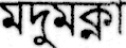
মদুমক্না
